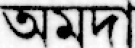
অমদা
